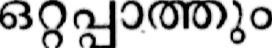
ഒറ്റപ്പാത്തും
